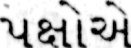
પક્ષોએ
